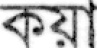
কয়া
